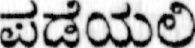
ಪಡೆಯಲಿ
